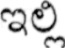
ಇಲ್ಲಿ
